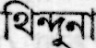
থিন্দুনা
